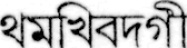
থমখিবদগী
